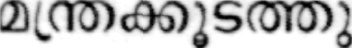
മന്ത്രക്കൂടത്തു
